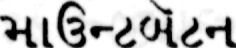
માઉન્ટબૅટન
